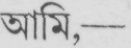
আমি,-
